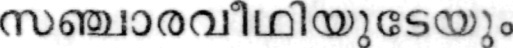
സഞ്ചാരവീഥിയുടേയും
